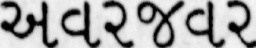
અવરજવર
